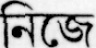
নিজে
